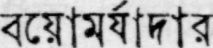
বয়োমর্যাদার
